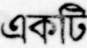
একটি
